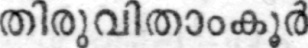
തിരുവിതാംകൂര്‍
